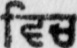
ਵਿਚ
